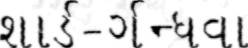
શાર્ડ-ર્ગન્ધવા
